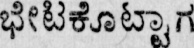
ಭೇಟಿಕೊಟ್ಟಾಗ
